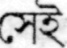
সেই
